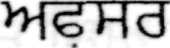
ਅਫ਼ਸਰ
